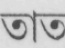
তাত
